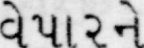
વેપારને
